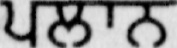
ਪਲਾਨ
